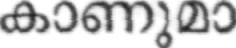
കാണുമാ
